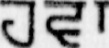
ਹਵਾ
